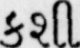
કશી
